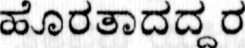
ಹೊರತಾದದ್ದರ
